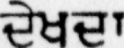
ਦੇਖਦਾ
